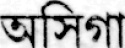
অসিগা
